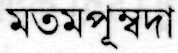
মতমপূম্বদা
